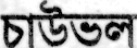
চাউভল
